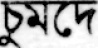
চুমদে
